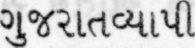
ગુજરાતવ્યાપી
